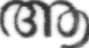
ആ
